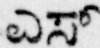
ಎಸ್
